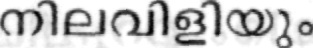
നിലവിളിയും
